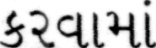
કરવામાં
